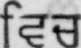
ਵਿਚ
